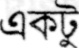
একটু
